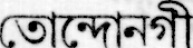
তেন্দোনগী
